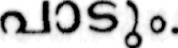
പാടും.
